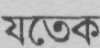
যতেক
